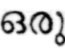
ഒരു
